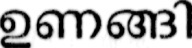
ഉണങ്ങി
